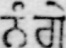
ਨੰਗੇ
